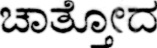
ಚಾತ್ತೋದ
